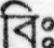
বিঃ
